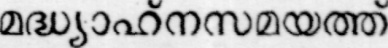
മദ്ധ്യാഹ്നസമയത്ത്
